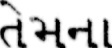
તેમના
